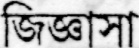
জিজ্ঞাসা
